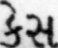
કેસ
